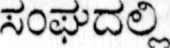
ಸಂಘದಲ್ಲಿ
